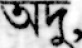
অদু,
